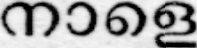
നാളെ
